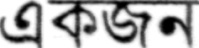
একজন
